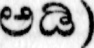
ಅಡಿ)
